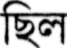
ছিল
